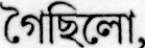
গৈছিলো,
